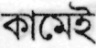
কামেই
